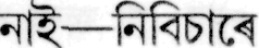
নাই-নিবিচাৰে
